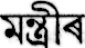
মন্ত্রীৰ
